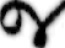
જ
